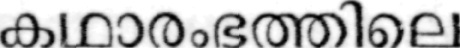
കഥാരംഭത്തിലെ
